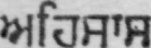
ਅਹਿਸਾਸ
